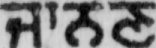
ਜਾਨਣ
